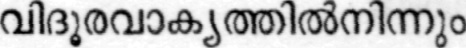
വിദൂരവാക്യത്തില്‍നിന്നും
